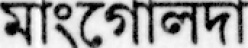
মাংগোলদা
